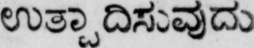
ಉತ್ಪಾದಿಸುವುದು
